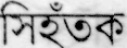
সিহঁতক
